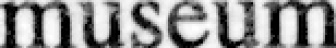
museum
